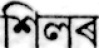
শিলৰ
